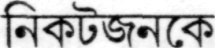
নিকটজনকে
